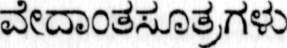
ವೇದಾಂತಸೂತ್ರಗಳು
